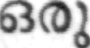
ഒരു
